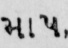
માપ,
